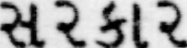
સરકાર
